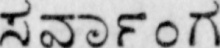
ಸರ್ವಾಂಗ
